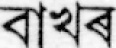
বাখৰ
